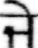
ਜੇ
